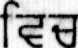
ਵਿਚ
